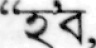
"হ'ব,
